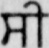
ਸੀ
